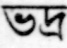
ভদ্র
